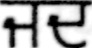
ਜਦ
